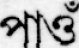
পাওঁ
